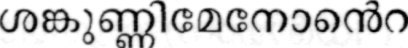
ശങ്കുണ്ണിമേനോന്റെ
